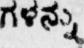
ಗಳನ್ನು
